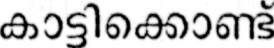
കാട്ടിക്കൊണ്ട്
